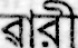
ৱারী
